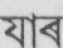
যাৰ
